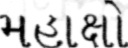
મહાક્ષો
